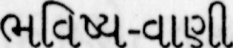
ભવિષ્ય-વાણી
